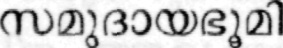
സമുദായഭൂമി
